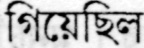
গিয়েছিল
